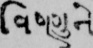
વિષ્ણુને
